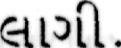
લાગી.
